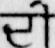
ਦੀ
